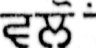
ਵਲੋਂ
